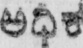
ಅಧಿಕ
